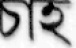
চাহ
